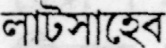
লাটসাহেব
